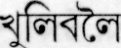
খুলিবলৈ
